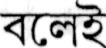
বলেই
